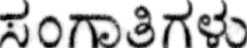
ಸಂಗಾತಿಗಳು
